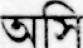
অসি
